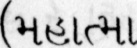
(મહાત્મા
